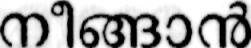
നീങ്ങാന്‍
